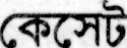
কেসেট
